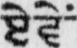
ਏਵੇਂ
